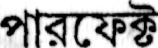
পারফেক্ট
